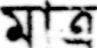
মাত্র
